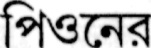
পিওনের
